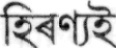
হিৰণ্যই
